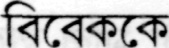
বিবেককে
